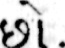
છો.
